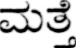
ಮತ್ತೆ
